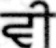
ਵੀ
